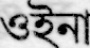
ওইনা
